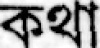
কথা
